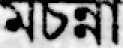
মচন্না
